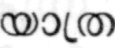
യാത്ര
